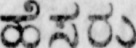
ಹೆಸರು
